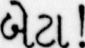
બેટા!
